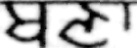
ਬਣਾ
